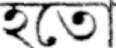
হতো
